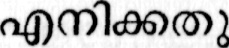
എനിക്കതു
